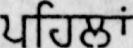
ਪਹਿਲਾਂ
